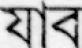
যাব
